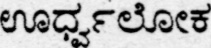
ಊರ್ಧ್ವಲೋಕ
